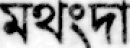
মথংদা
